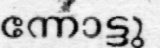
ന്നോട്ടു
